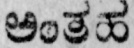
ಅಂತಹ
